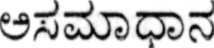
ಅಸಮಾಧಾನ
